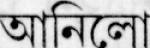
আনিলো
